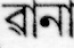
ৱানা
